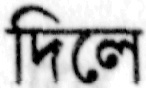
দিলে
